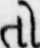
તો
